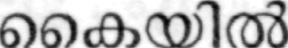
കൈയില്‍
